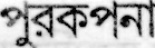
পুরকপনা
